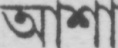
আশা
